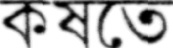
কষতে
